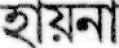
হায়না
